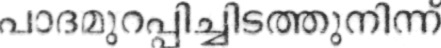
പാദമുറപ്പിച്ചിടത്തുനിന്ന്
